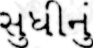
સુધીનું
